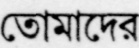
তোমাদের
